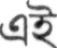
এই
